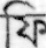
ফি
